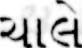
ચાલે
